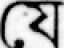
যে
